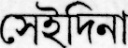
সেইদিনা
